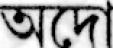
অদো
